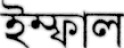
ইম্ফাল
